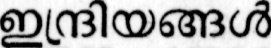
ഇന്ദ്രിയങ്ങള്‍
